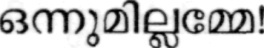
ഒന്നുമില്ലമ്മേ!
